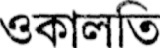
ওকালতি
